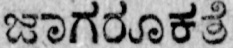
ಜಾಗರೂಕತೆ
